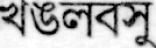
খঙলবসু
